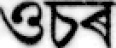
ওচৰ
